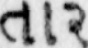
તાર
